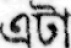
এটা
